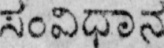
ಸಂವಿಧಾನ
